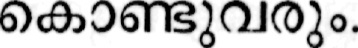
കൊണ്ടുവരും.
